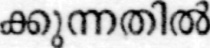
ക്കുന്നതില്‍
